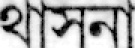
থাসনা
